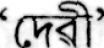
'দেৱী'
